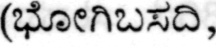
(ಭೋಗಿಬಸದಿ,
